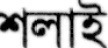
শলাই
